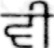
ਵੀ
